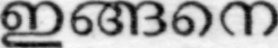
ഇങ്ങനെ
